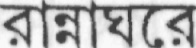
রান্নাঘরে
